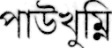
পাউখুম্নি
